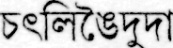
চৎলিঙৈদুদা
